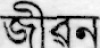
জীৱন
